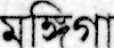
মঙ্গিগা
